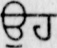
ਉਹ
